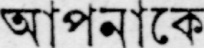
আপনাকে
